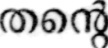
തന്റെ
